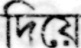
দিয়ে
